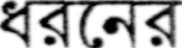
ধরনের
